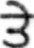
ਤੇ
